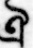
ঐ
